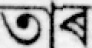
তাৰ
